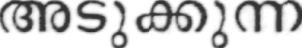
അടുക്കുന്ന
